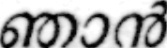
ഞാള്‍
